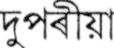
দুপৰীয়া
